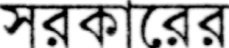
সরকারের
